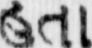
હતા
